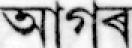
আগৰ
